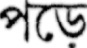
পড়ে
